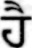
ਹੈ
